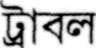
ট্রাবল
